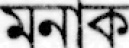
মনাক
